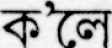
ক'লে
